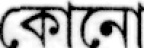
কোনো
